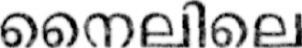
നൈലിലെ
